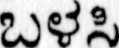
ಬಳಸಿ
